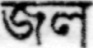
জল
